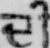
ਦੀ
